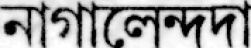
নাগালেন্দদা
